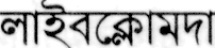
লাইবক্লোমদা
